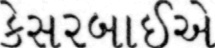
કેસરબાઈએ
